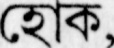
হোক,
